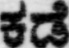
ಕಡೆ
